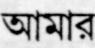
আমার
